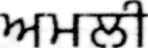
ਅਮਲੀ
